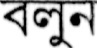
বলুন
